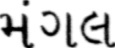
મંગલ
